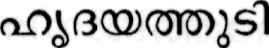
ഹൃദയത്തുടി
